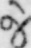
જે
